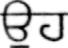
ਉਹ
